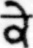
ਕੇ
